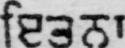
ਇਤਨਾ
